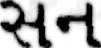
સન
